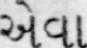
એવા
